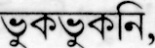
ভুকভুকনি,
